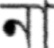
না
